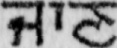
ਜਾਣ
